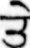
ਤੇ
